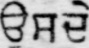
ਉਸਦੇ
